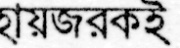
হায়জরকই
